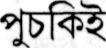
পুচকিই
